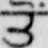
ਤੋਂ
